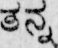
ತನ್ನ
